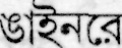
ঙাইনরে
